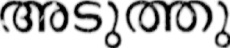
അടുത്തു
